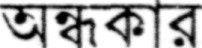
অন্ধকার
